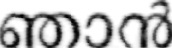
ഞാന്‍
